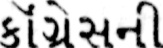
કૉંગ્રેસની
